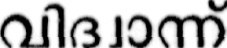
വിദ്വാന്ന്
